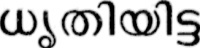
ധൃതിയിട്ട
